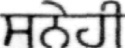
ਸਨੇਹੀ
